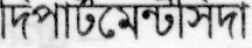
দিপার্টমেন্টসিদা
